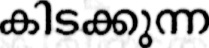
കിടക്കുന്ന
